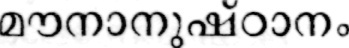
മൌനാനുഷ്ഠാനം
